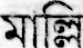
মাল্লি
